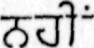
ਨਹੀਂ
